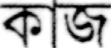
কাজ
